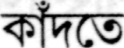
কাঁদতে
